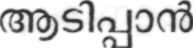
ആടിപ്പാന്‍
